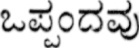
ಒಪ್ಪಂದವು
